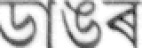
ডাঙৰ
